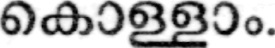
കൊള്ളാം.
